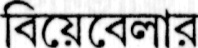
বিয়েবেলার
